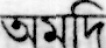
অমদি
